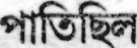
পাতিছিল
